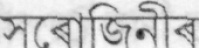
সৰোজিনীৰ
